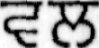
ਵਲ
